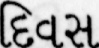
દિવસ
